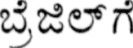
ಬ್ರೆಜಿಲ್ಗೆ
